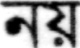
নয়
